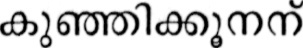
കുഞ്ഞിക്കൂനന്
